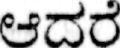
ಆದರೆ
